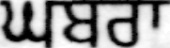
ਘਬਰਾ
